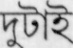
দুটাই
